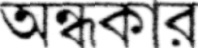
অন্ধকার
